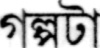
গল্পটা
